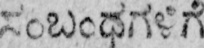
ಸಂಬಂಧಗಳಿಗೆ
